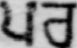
ਪਰ
